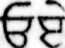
ਓਏ
